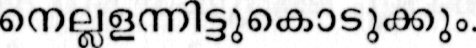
നെല്ലളന്നിട്ടുകൊടുക്കും.
